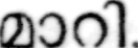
മാറി.
